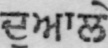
ਦੁਆਲੇ
